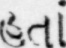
હતાં
